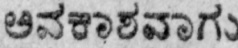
ಅವಕಾಶವಾಗು
